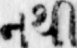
નથી
